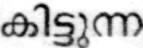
കിട്ടുന്ന
